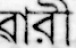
ৱারী
